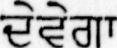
ਦੇਵੇਗਾ
